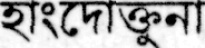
হাংদোক্তুনা
